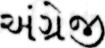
અંગ્રેજી
